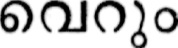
വെറും
